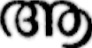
ആ
